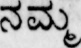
ನಮ್ಮ
